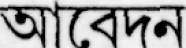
আবেদন
